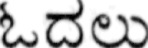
ಓದಲು
